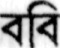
ববি
